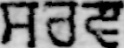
ਸਰਵ
